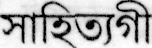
সাহিত্যগী
